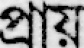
প্রায়
